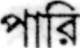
পারি
